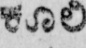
ಕೂಲಿ
